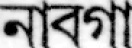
নাবগা
